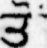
ਤੋਂ
